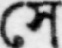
সে
